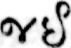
જઈ
